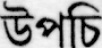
উপচি
